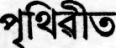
পৃথিৱীত
